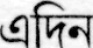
এদিন
